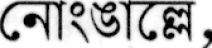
নোংঙাল্লে,
